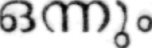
ഒന്നും
